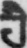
ਹੈ
